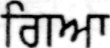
ਗਿਆ
